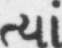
ત્યાં
